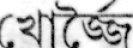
খোর্জ্জৈ
